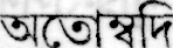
অতোম্বদি
